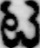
ಟ
